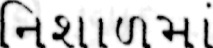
નિશાળમાં
